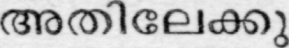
അതിലേക്കു
